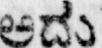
ಅದು
